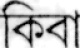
কিবা
